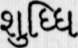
શુધ્ધિ
